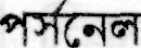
পর্সনেল
